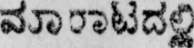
ಮಾರಾಟದಲ್ಲಿ
